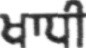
ਖਾਧੀ
